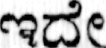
ಇದೇ
